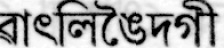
ৱাৎলিঙৈদগী
